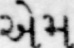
એમ
